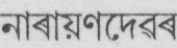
নাৰায়ণদেৱৰ
